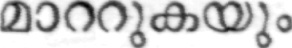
മാററുകയും
